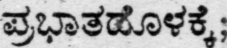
ಪ್ರಭಾತದೊಳಕ್ಕೆ,
